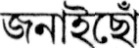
জনাইছোঁ
